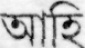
আহি
